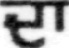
ਦਾ
